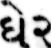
ઘેર
